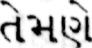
તેમણે
